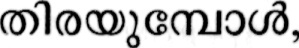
തിരയുമ്പോള്‍,
